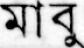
মাবু
